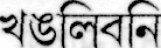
খঙলিবনি
